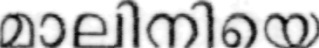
മാലിനിയെ
